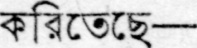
করিতেছে—
